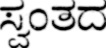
ಸ್ವಂತದ
